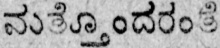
ಮತ್ತೊಂದರಂತೆ
